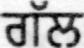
ਗੱਲ
